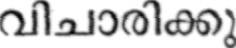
വിചാരിക്കു
